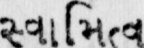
સ્વામિત્વ
